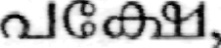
പക്ഷേ,
